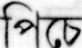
পিচে
